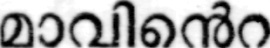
മാവിന്റെ
